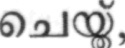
ചെയ്ത്,
